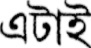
এটাই
